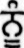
ਨੂੰ
